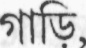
গাড়ি,
